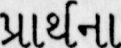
પ્રાર્થના
